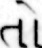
તો
